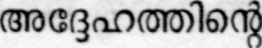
അദ്ദേഹത്തിന്റെ
